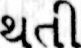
થતી
